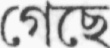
গেছে
